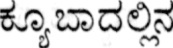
ಕ್ಯೂಬಾದಲ್ಲಿನ
